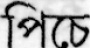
পিচে
